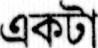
একটা
